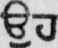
ਉਹ
